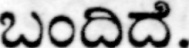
ಬಂದಿದೆ.
